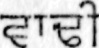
ਵਾਢੀ
